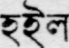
হইল
